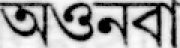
অওনবা
